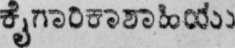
ಕೈಗಾರಿಕಾಶಾಹಿಯು
